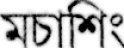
মচাশিং
